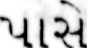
પાસે
